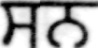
ਸਨ
